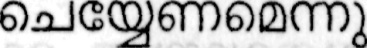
ചെയ്യേണമെന്നു
